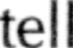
tell
